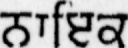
ਨਾਇਕ
